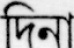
দিনা
